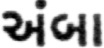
અંબા
